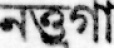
নত্ত্রগা
